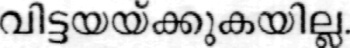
വിട്ടയയ്ക്കുകയില്ല.
